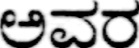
ಅವರ
